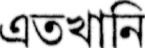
এতখানি
